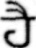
ਹੈ
